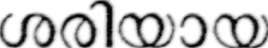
ശരിയായ
